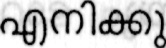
എനിക്കു
